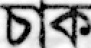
চাক
